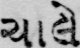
ચાલે
